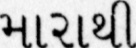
મારાથી
